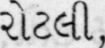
રોટલી,
